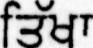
ਤਿੱਖਾ
